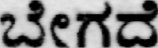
ಬೇಗದೆ
